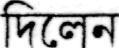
দিলেন
